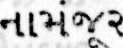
નામંજૂર
